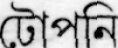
টোপনি
